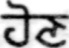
ਹੋਣ
